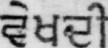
ਵੇਖਦੀ
